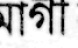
মাগী
